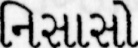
નિસાસો
